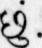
છું.
